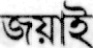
জয়াই
